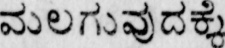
ಮಲಗುವುದಕ್ಕೆ
